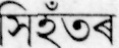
সিহঁতৰ
